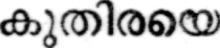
കുതിരയെ
